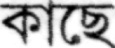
কাছে
